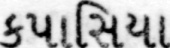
કપાસિયા
